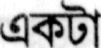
একটা
